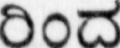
ರಿಂದ
